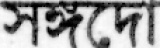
সঙ্গদো
